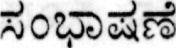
ಸಂಭಾಷಣೆ
